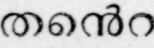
തന്റെ
